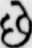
છે
